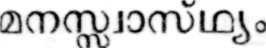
മനസ്സ്വാസ്ഥ്യം
